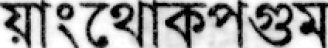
য়াংথোকপগুম
